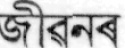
জীৱনৰ
